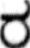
ರ
